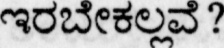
ಇರಬೇಕಲ್ಲವೆ?
